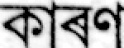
কাৰণ
